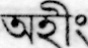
অহীং
